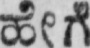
ಹೇಗೆ
